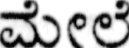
ಮೇಲೆ
